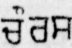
ਚੌਰਸ
